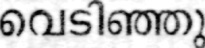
വെടിഞ്ഞു
